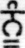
ਨੂੰ
